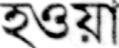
হওয়া
